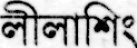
লীলাশিং
